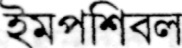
ইমপশিবল
